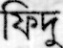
ফিদু
